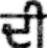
ਦੀ
